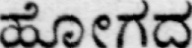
ಹೋಗದ
